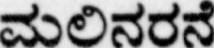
ಮಲಿನರನೆ
